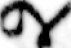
જ
